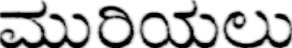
ಮುರಿಯಲು
